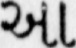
આ
